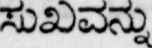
ಸುಖವನ್ನು
